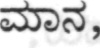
ಮಾನ,
